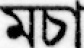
মচা
